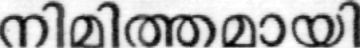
നിമിത്തമായി
